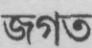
জগত
